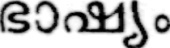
ഭാഷ്യം
